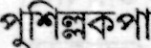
পুশিল্লকপা
